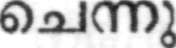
ചെന്നു
